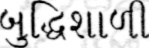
બુદ્ધિશાળી
